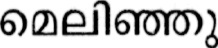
മെലിഞ്ഞു
